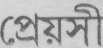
প্ৰেয়সী
